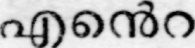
എന്റെ
